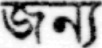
জন্য
